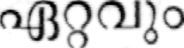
ഏറ്റവും
